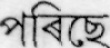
পৰিছে
